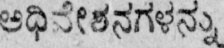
ಅಧಿವೇಶನಗಳನ್ನು
